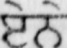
ਏਨੇ
